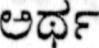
ಅರ್ಥ
